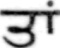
ਤਾਂ
